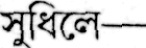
সুধিলে-
